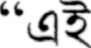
“এই
